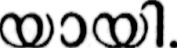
യായി.
